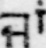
ਜਾਂ
